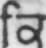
ਕਿ
